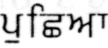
ਪੁਛਿਆ
